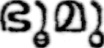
ഭൂമു
